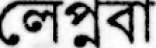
লেপ্নবা
